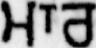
ਮਾਰ
